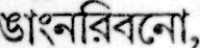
ঙাংনরিবনো,
